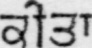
ਕੀਤਾ
